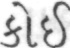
કોઈ
